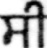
ਸੀ
